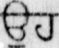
ਉਹ
